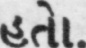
હતો.
